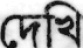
দেখি
